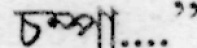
চম্পা...."
